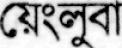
য়েংলুবা
